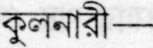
কুলনারী–
